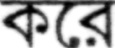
করে
